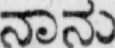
ನಾನು
